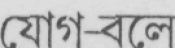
যোগ-বলে
